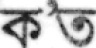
ক'ত
